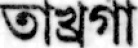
তাখ্রগা
